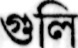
গুলি
